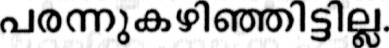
പരന്നുകഴിഞ്ഞിട്ടില്ല.
